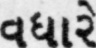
વધારે
